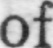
of
